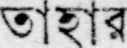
তাহার
